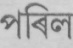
পৰিল
